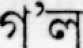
গ'ল
